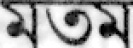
মতম
